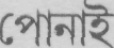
পোনাই
